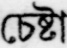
চেষ্টা
